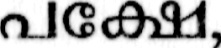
പക്ഷേ,
